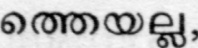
ത്തെയല്ല,
